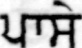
ਪਾਸੇ
